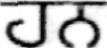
ਹਨ
